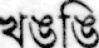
খঙঙি
